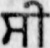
ਸੀ
